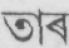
তাৰ
